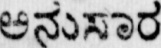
ಅನುಸಾರ
